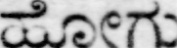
ಹೋಗು
